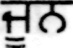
ਜੂਨ
